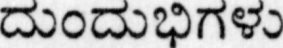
ದುಂದುಭಿಗಳು
